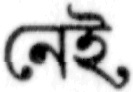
নেই,
